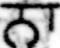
ਨਾ
